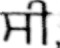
ਸੀ,
